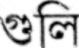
গুলি
